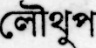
লৌথুপ
